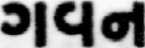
ગવન
